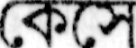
কেসে
